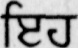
ਇਹ
